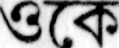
ওকে
